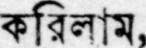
করিলাম,
